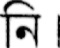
নি।
